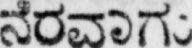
ನೆರವಾಗು
